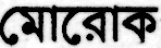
মোরোক
